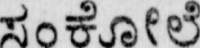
ಸಂಕೋಲೆ
